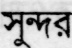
সুন্দর
